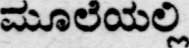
ಮೂಲೆಯಲ್ಲಿ
